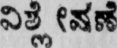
ವಿಶ್ಲೇಷಣೆ
